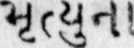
મૃત્યુના
